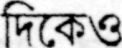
দিকেও
